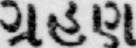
ગ્રહણ
